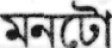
মনটো
